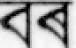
বৰ
